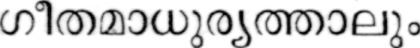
ഗീതമാധുര്യത്താലും
